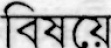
বিষয়ে
